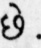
છે.
